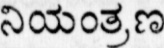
ನಿಯಂತ್ರಣ
